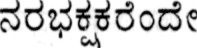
ನರಭಕ್ಷಕರೆಂದೇ
